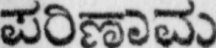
ಪರಿಣಾಮ
